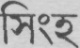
সিংহ
